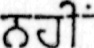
ਨਹੀਂ
